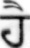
ਹੈ
